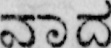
ವಾದ
